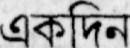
একদিন
